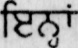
ਇਨ੍ਹਾਂ
